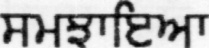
ਸਮਝਾਇਆ
